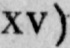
xv)
